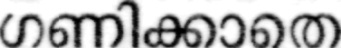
ഗണിക്കാതെ
